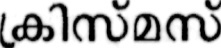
ക്രിസ്മസ്
